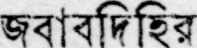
জবাবদিহির
